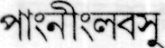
পাংনীংলবসু
